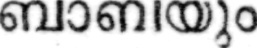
ബാബയും
